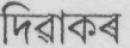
দিৱাকৰ
